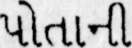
પોતાની
